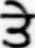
ਤੇ
